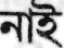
নাই
